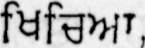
ਖਿਚਿਆ,
